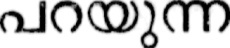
പറയുന്ന
